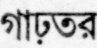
গাঢ়তর
